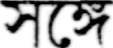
সঙ্গে
